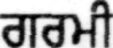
ਗਰਮੀ
